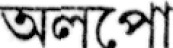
অলপো
